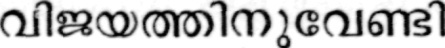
വിജയത്തിനുവേണ്ടി
